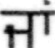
ਜਾਂ
